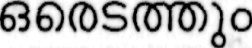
ഒരെടത്തും
